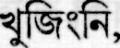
খুজিংনি,
